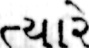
ત્યારે
